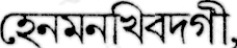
হেনমনখিবদগী,
